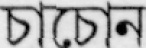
চাচোন
